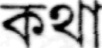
কথা
